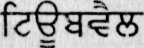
ਟਿਊਬਵੈਲ
